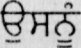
ਉਸਨੂੰ
